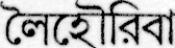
লৈহৌরিবা
